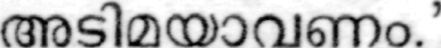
അടിമയാവണം.’
